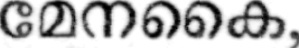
മേനകൈ,
